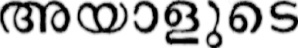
അയാളുടെ
